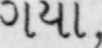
ગયા,
